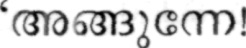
'അങ്ങുന്നേ!
